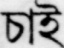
চাই
